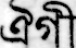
ঐগী
